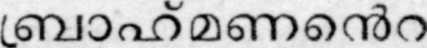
ബ്രാഹ്മണന്റെ
